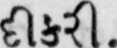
દીકરી.
